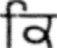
ਕਿ
